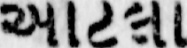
આટલા
